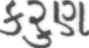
કરુણ
